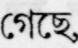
গেছে,
